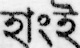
হাংই
